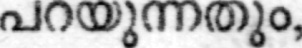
പറയുന്നതും,
